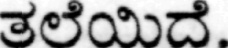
ತಲೆಯಿದೆ.
